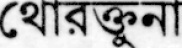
থোরক্তুনা
